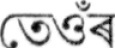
তেওঁৰ
